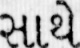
સાથે
